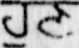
ਹੁਣ
